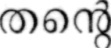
തന്റെ
